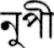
নুপী
